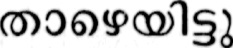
താഴെയിട്ടു
